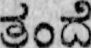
ತಂದೆ
